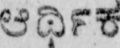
ಆರ್ಥಿಕ
